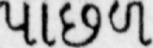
પાછળ
